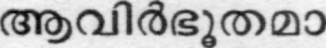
ആവിര്‍ഭൂതമാ
